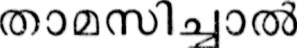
താമസിച്ചാല്‍
